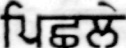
ਪਿਛਲੇ
